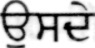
ਉਸਦੇ
